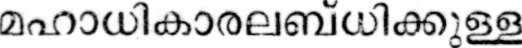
മഹാധികാരലബ്ധിക്കുള്ള
